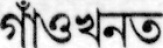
গাঁওখনত
